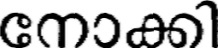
നോക്കി
